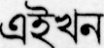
এইখন
